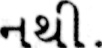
નથી.
